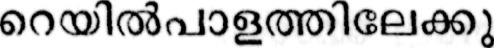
റെയില്‍പാളത്തിലേക്കു
